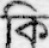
কি
